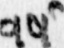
વર્ષ
